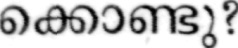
ക്കൊണ്ടു?
